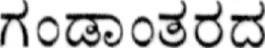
ಗಂಡಾಂತರದ
